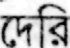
দেরি
